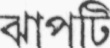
ঝাপটি
